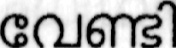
വേണ്ടി
